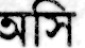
অসি
